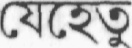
যেহেতু
